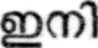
ഇനി
